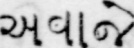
અવાજે
